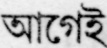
আগেই
